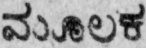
ಮೂಲಕ
